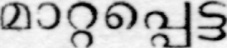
മാറ്റപ്പെട്ട
